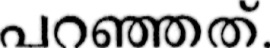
പറഞ്ഞത്.
